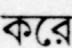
করে
